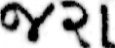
જરા
